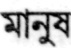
মানুষ
